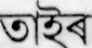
তাইৰ
